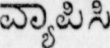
ವ್ಯಾಪಿಸಿ
